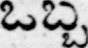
ಒಬ್ಬ
